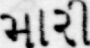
મારી
